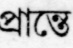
প্রান্তে
